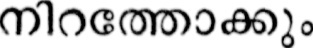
നിറത്തോക്കും
